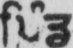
ਪਿੰਡ
